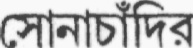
সোনাচাঁদির
